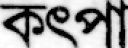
কৎপা
